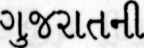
ગુજરાતની
